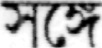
সঙ্গে
